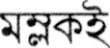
মম্লকই
